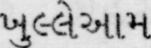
ખુલ્લેઆમ
